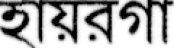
হায়রগা
